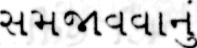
સમજાવવાનું
